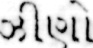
ઝીણો
